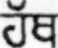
ਹੱਥ
